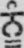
ਨੂੰ
